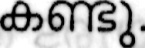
കണ്ടു.
